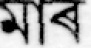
মাৰ
